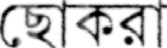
ছোকরা
